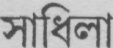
সাধিলা
